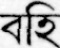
বহি
